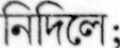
নিদিলে;
